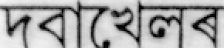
দবাখেলৰ
